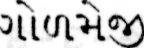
ગોળમેજી
